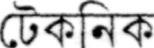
টেকনিক
